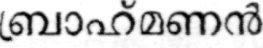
ബ്രാഹ്മണന്‍
